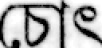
চোৎ
